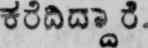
ಕರೆದಿದ್ದಾರೆ.
